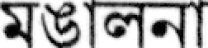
মঙালনা
